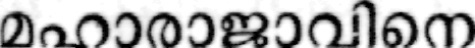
മഹാരാജാവിനെ
